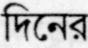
দিনের
